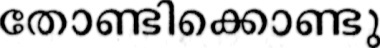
തോണ്ടിക്കൊണ്ടു
